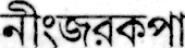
নীংজরকপা
